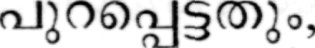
പുറപ്പെട്ടതും,
